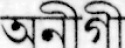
অনীগী
